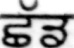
ਛੱਡ
